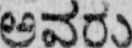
ಅವರು
